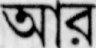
আর
